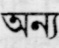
অন্য
